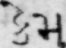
કેમ
